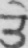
ਤੇ
